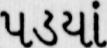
પડયાં
